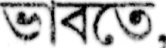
ভাবতে,
